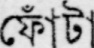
ফোঁটা
